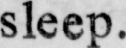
sleep.
